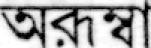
অরূম্বা
